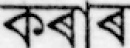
কৰাৰ
